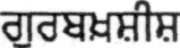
ਗੁਰਬਖ਼ਸ਼ੀਸ਼
